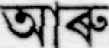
আৰু
